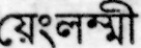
য়েংলম্মী
